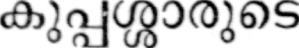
കുപ്പശ്ശാരുടെ
